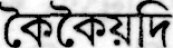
কৈকৈয়দি
